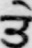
ਤੇ
